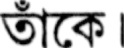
তাঁকে।
